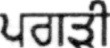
ਪਗੜੀ
